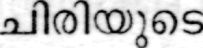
ചിരിയുടെ
